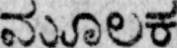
ಮೂಲಕ
